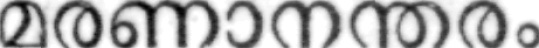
മരണാനന്തരം
